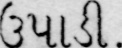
ઉપાડી.
